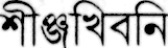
শীঞ্জখিবনি
